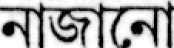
নাজানো
